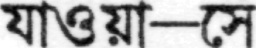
যাওয়া—সে
